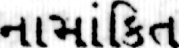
નામાંકિત
